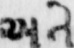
અને
